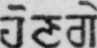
ਹੋਣਗੇ
